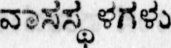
ವಾಸಸ್ಥಳಗಳು
